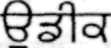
ਉਡੀਕ
